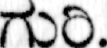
ಗುರಿ.
